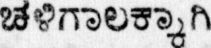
ಚಳಿಗಾಲಕ್ಕಾಗಿ
